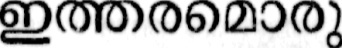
ഇത്തരമൊരു
